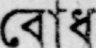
বোধ
